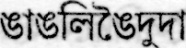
ঙাঙলিঙৈদুদা
